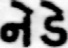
નેડે
